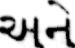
અને
